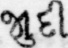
જુદી
